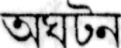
অঘটন
